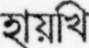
হায়খি
